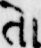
તો
